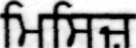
ਮਿਸਿਜ਼
